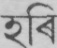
হৰি
